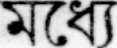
মধ্যে
